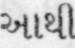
આથી
